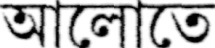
আলোতে
